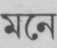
মনে
